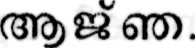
ആജ്ഞ.
